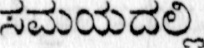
ಸಮಯದಲ್ಲಿ
